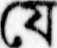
যে
